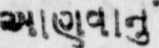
આણવાનું
